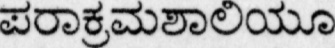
ಪರಾಕ್ರಮಶಾಲಿಯೂ
